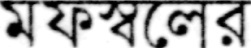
মফস্বলের
